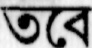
তবে
